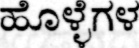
ಹೊಳ್ಳೆಗಳ
